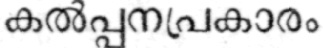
കല്‍പ്പനപ്രകാരം
